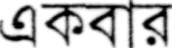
একবার
